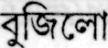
বুজিলো
